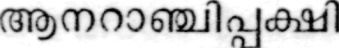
ആനറാഞ്ചിപ്പക്ഷി
